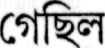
গেছিল
